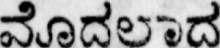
ಮೊದಲಾದ
